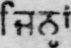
ਜਿਨ੍ਹਾਂ
